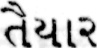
તૈયાર
